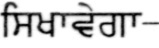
ਸਿਖਾਵੇਗਾ-
